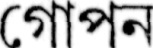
গোপন
